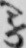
કે
